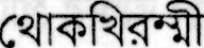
থোকখিরম্মী
